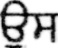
ਉਸ
